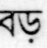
বড়
